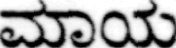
ಮಾಯ
